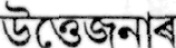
উত্তেজনাৰ
